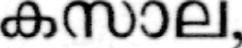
കസാല,
